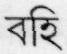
বহি
